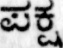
ಪಕ್ಷ
